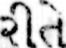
રીતે
